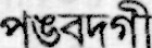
পঙবদগী
